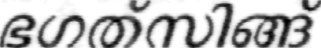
ഭഗത്‌സിങ്ങ്
